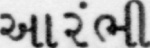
આરંભી
